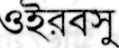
ওইরবসু
